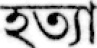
হত্যা
